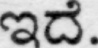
ಇದೆ.
